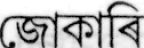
জোকাৰি
